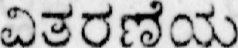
ವಿತರಣೆಯ
